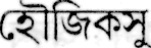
হৌজিকসু
